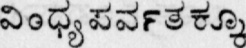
ವಿಂಧ್ಯಪರ್ವತಕ್ಕೂ
